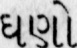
ઘણો
